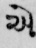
એ
